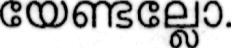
യേണ്ടല്ലോ.
